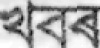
খবৰ
